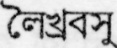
লৈখ্রবসু
